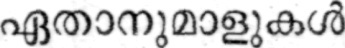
ഏതാനുമാളുകള്‍
